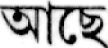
আছে
